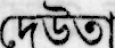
দেউতা
